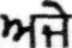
ਅਜੇ
